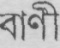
বাণী
